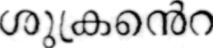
ശുക്രന്റെ
